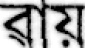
ৱায়
